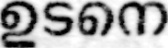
ഉടനെ
